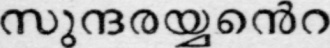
സുന്ദരയ്യന്റെ
